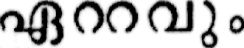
ഏററവും
